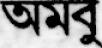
অমবু
